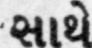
સાથે
